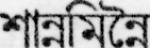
শান্নমিন্নৈ
